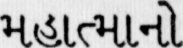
મહાત્માનો
